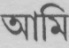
আমি
